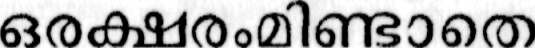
ഒരക്ഷരംമിണ്ടാതെ
